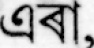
এৰা,
